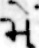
મેં
